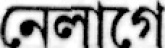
নেলাগে
